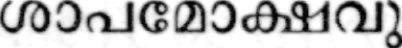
ശാപമോക്ഷവു
